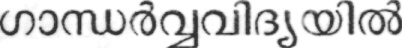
ഗാന്ധര്‍വ്വവിദ്യയില്‍
